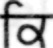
ਕਿ
